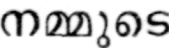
നമ്മുടെ
